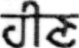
ਹੀਣ
